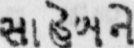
સાહેબને
